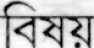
বিষয়
